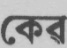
কেৱ
